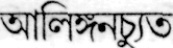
আলিঙ্গনচ্যুত
